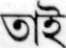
তাই
